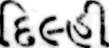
દિલ્હી
